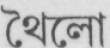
থৈলো
